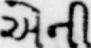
એની
